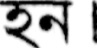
হন।
